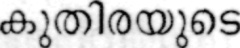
കുതിരയുടെ
